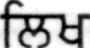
ਲਿਖ
